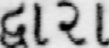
દ્વારા
